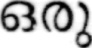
ഒരു
